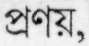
প্ৰণয়,
